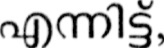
എന്നിട്ട്,
